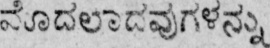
ಮೊದಲಾದವುಗಳನ್ನು
